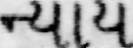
ન્યાય
